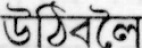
উঠিবলৈ
